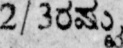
2/3ರಷ್ಟು
